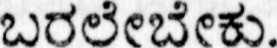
ಬರಲೇಬೇಕು.
